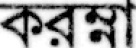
করম্না
